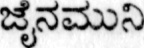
ಜೈನಮುನಿ
